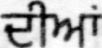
ਦੀਆਂ
